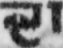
ਦਾ
